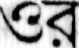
ওর
